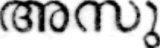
അസു
